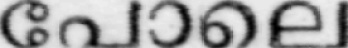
പോലെ
